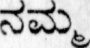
ನಮ್ಮ
